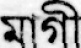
মাগী
